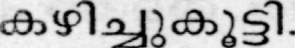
കഴിച്ചുകൂട്ടി.
